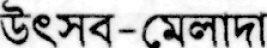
উৎসব-মেলাদা
